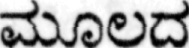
ಮೂಲದ
